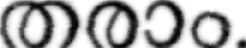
തരാം.
